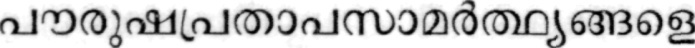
പൗരുഷപ്രതാപസാമര്‍ത്ഥ്യങ്ങളെ
